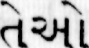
તેઓ
